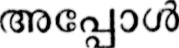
അപ്പോള്‍
